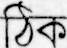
ঠিক
